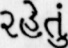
રહેતું
